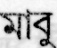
মাবু
